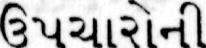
ઉપચારોની
